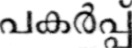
പകര്‍പ്പ്
